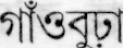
গাঁওবুঢ়া
